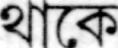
থাকে
